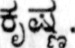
ಕೃಷ್ಣ.
